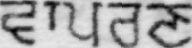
ਵਾਪਰਣ
